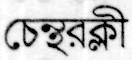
চেন্থরক্লী
